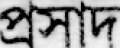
প্রসাদ
